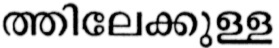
ത്തിലേക്കുള്ള
